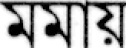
মমায়
